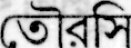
তৌরসি
